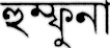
হুম্ফুনা
